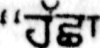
''ਹੱਛਾ
